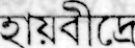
হায়বীদ্রে
